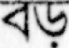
বড়
